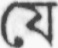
যে
